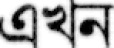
এখন
